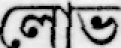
লোভ
